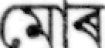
মোৰ
